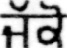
ਜੱਕੋ
